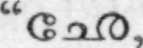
"ഛേ,
